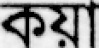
কয়া
